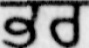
ਭਰ
